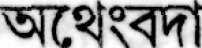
অথেংবদা
